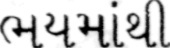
ભયમાંથી
